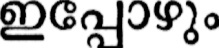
ഇപ്പോഴും
